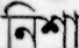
নিশা
